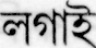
লগাই
